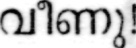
വീണു!
